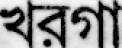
খরগা
